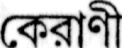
কেরাণী
